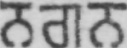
ਨਗਨ
